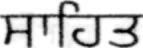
ਸਾਹਿਤ
